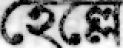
হেল্লে
